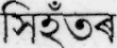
সিহঁতৰ
